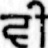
ਵੀ
